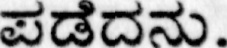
ಪಡೆದನು.
